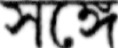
সঙ্গে
